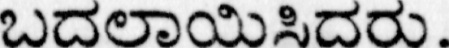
ಬದಲಾಯಿಸಿದರು.
